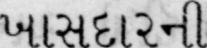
ખાસદારની
